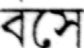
বসে
